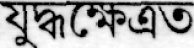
যুদ্ধক্ষেত্রত
